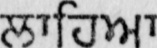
ਲਾਹਿਆ
